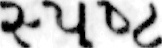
સ્પષ્ટ
